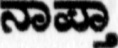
ನಾಪ್ತಾ
